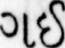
ગઈ
